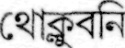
থোক্লুবনি
